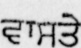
ਵਾਸਤੇ
